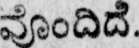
ವೊಂದಿದೆ.
